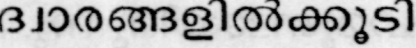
ദ്വാരങ്ങളില്‍ക്കൂടി
